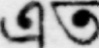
এত
